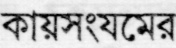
কায়সংযমের
